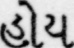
હોય
